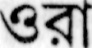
ওরা
